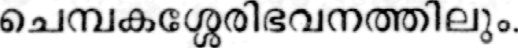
ചെമ്പകശ്ശേരിഭവനത്തിലും.
